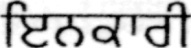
ਇਨਕਾਰੀ
